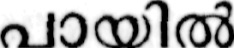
പായില്‍
